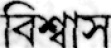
বিশ্বাস
